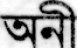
অনী
